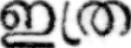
ഇത്ര
